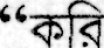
“করি
